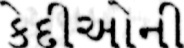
કેદીઓની
